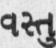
વસ્તુ
